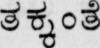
ತಕ್ಕಂತೆ
